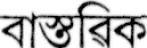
বাস্তৱিক
